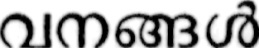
വനങ്ങള്‍
